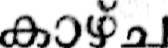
കാഴ്ച
